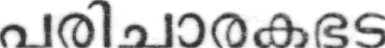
പരിചാരകഭട
